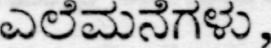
ಎಲೆಮನೆಗಳು,
